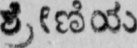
ಶ್ರೇಣಿಯ
